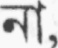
না,
